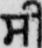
ਸੀ
